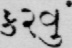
કરવું
